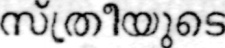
സ്ത്രീയുടെ
